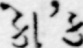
કો'ક
